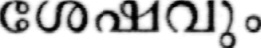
ശേഷവും
